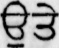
ਉਤੇ
